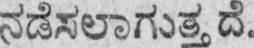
ನಡೆಸಲಾಗುತ್ತದೆ.
